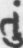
તું
